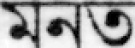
মনত
